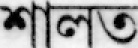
শালত
